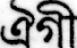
ঐগী
